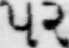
પર
